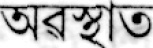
অৱস্থাত
